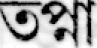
তপ্না
